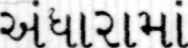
અંધારામાં
